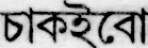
চাকইকো
